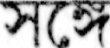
সঙ্গে
